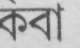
কিবা
